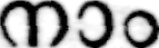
നാം
